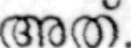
അത്.
